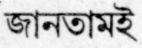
জানতামই
